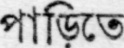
পাড়িতে
